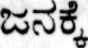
ಜನಕ್ಕೆ
